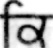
ਕਿ
